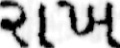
રાખ
